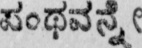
ಪಂಥವನ್ನೇ
